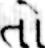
તો
